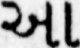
આ
